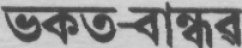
ভকত-বান্ধৱ
